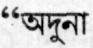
“অদুনা
